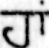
ਹਾਂ
